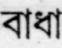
বাধা
